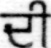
ਦੀ
